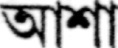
আশা
